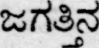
ಜಗತ್ತಿನ
